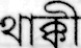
থাক্কী
